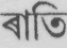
ৰাতি
